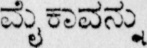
ಮೈಕಾವನ್ನು
